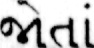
જોતાં
